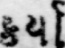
કર્યા
